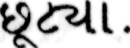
છૂટ્યા.
